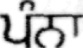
ਪੰਨਾ
